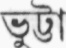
ভুট্টা
